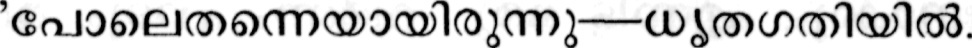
'പോലെതന്നെയായിരുന്നു-ധൃതഗതിയില്‍.
